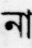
না
